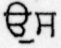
ਉਸ
